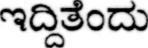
ಇದ್ದಿತೆಂದು
